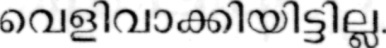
വെളിവാക്കിയിട്ടില്ല.
